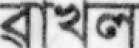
ৱাখল
